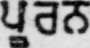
ਪੂਰਨ
